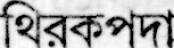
থিরকপদা
